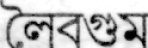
লৈবগুম
